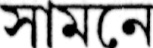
সামনে
